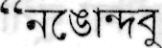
“নঙোন্দবু
